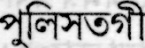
পুলিসতগী
